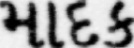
માદક
